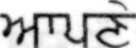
ਆਪਣੇ
